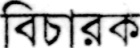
বিচারক
